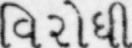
વિરોધી
